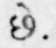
છે.
